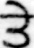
ਤੇ
